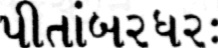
પીતાંબરધરઃ
